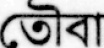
তৌবা
